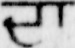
ਦਾ
